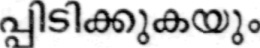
പ്പിടിക്കുകയും
